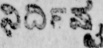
ನಿರ್ದಿಷ್ಟ
